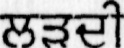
ਲੜਦੀ
